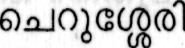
ചെറുശ്ശേരി
